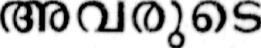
അവരുടെ
